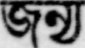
জন্য
